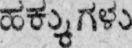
ಹಕ್ಕುಗಳು
